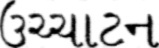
ઉચ્ચાટન
